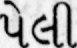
પેલી
